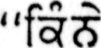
''ਕਿੰਨੇ
